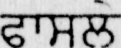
ਫਾਸਲੇ
